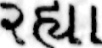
રહ્યા
